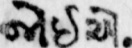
જોઈએ.
